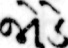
જોડે
